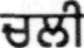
ਚਲੀ
